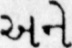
અને
